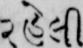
રહેલી
